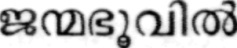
ജന്മഭൂവില്‍
